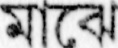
মাঝে
